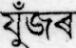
যুঁজৰ
